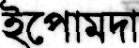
ইপোমদা
